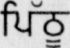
ਪਿੱਠੂ
